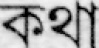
কথা
